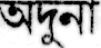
অদুনা
